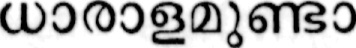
ധാരാളമുണ്ടാ
